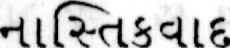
નાસ્તિકવાદ
